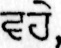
ਵਹੇ,
